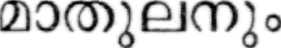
മാതുലനും
